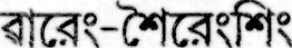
ৱারেং-শৈরেংশিং
